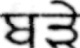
ਬੜੇ
